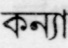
কন্যা
